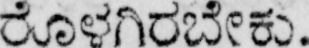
ರೊಳಗಿರಬೇಕು.
